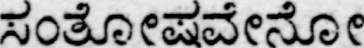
ಸಂತೋಷವೇನೋ
